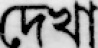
দেখা
